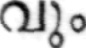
വും
